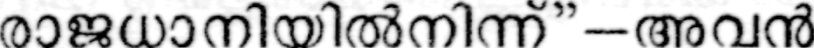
രാജധാനിയില്‍നിന്ന്”-അവന്‍
